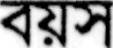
বয়স
